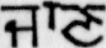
ਜਾਣ
